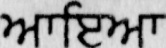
ਆਇਆ
